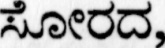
ಸೋರದ,
